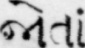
જોતાં
